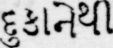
દુકાનેથી
